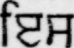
ਇਸ
